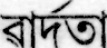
ৱার্দতা
